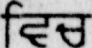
ਵਿਚ
